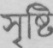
সৃষ্টি
